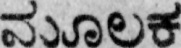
ಮೂಲಕ
